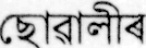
ছোৱালীৰ
